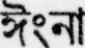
ঈংনা
